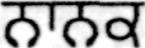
ਨਾਨਕ
